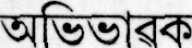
অভিভাৱক
